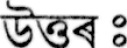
উত্তৰঃ
